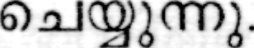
ചെയ്യുന്നു.
